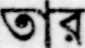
তার
